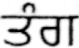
ਤੰਗ
